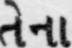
તેના
